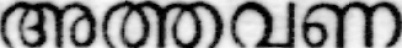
അത്തവണ
